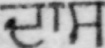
ਦਾਸ
